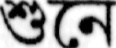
শুনে
